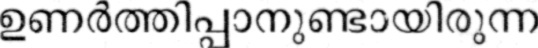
ഉണര്‍ത്തിപ്പാനുണ്ടായിരുന്ന
